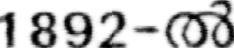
1892-ല്‍
